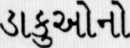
ડાકુઓનો
